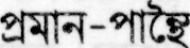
প্রমান-পান্থৈ
